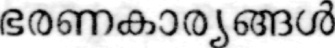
ഭരണകാര്യങ്ങള്‍
